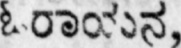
ಓರಾಯನ,
